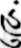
હું
